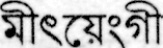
মীৎয়েংগী
